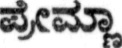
ಪ್ರೇಮ್ಲಾ
